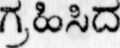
ಗ್ರಹಿಸಿದ
